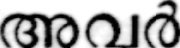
അവര്‍
